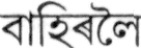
বাহিৰলৈ
